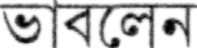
ভাবলেন
